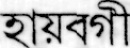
হায়বগী
